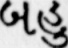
બહુ
